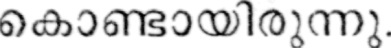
കൊണ്ടായിരുന്നു.
